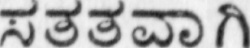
ಸತತವಾಗಿ
